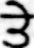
ਤੇ
